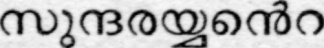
സുന്ദരയ്യന്റെ
